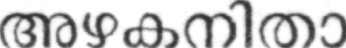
അഴകനിതാ
